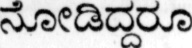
ನೋಡಿದ್ದರೂ
